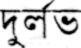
দুর্লভ
